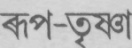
ৰূপ-তৃষ্ণা
